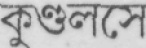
কুণ্ডলসে
